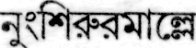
নুংশিরুরমাল্লে
